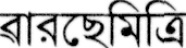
ৱারছেমিত্রি
